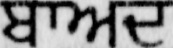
ਬਾਅਦ
